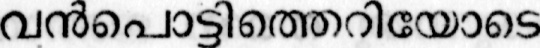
വന്‍പൊട്ടിത്തെറിയോടെ
